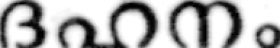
ദഹനം
